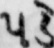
પડે
